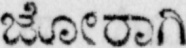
ಜೋರಾಗಿ
